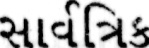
સાર્વત્રિક
